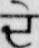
ਦੇ
